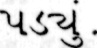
પડ્યું.
